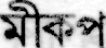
মীকপ
